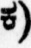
ಕ)
